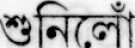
শুনিলোঁ
